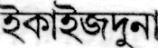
ইকাইজদুনা
